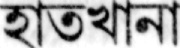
হাতখানা
